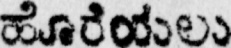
ಹೊರೆಯಲು
